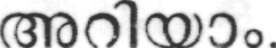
അറിയാം.
